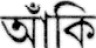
আঁকি
